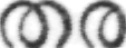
തര
